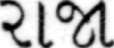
રાજા
